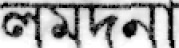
লমদনা
